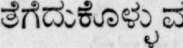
ತೆಗೆದುಕೊಳ್ಳುವ
